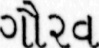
ગૌરવ
